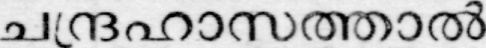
ചന്ദ്രഹാസത്താല്‍
